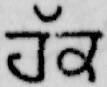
ਹੱਕ
